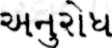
અનુરોધ
